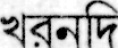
খরনদি
